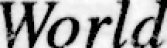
World
